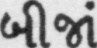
બીજાં
